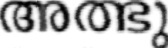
അത്ഭു
